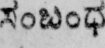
ಸಂಬಂಧ
